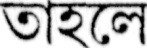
তাহলে
